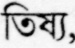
তিষ্য,
